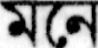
মনে
